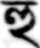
হু
